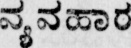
ವ್ಯವಹಾರ
